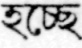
হচ্ছে
